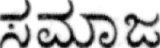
ಸಮಾಜ
